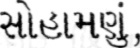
સોહામણું,
